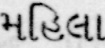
મહિલા
